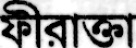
ফীরাক্তা
